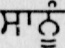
ਸਾਨੂੰ
